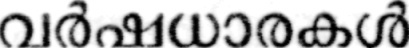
വര്‍ഷധാരകള്‍
